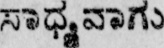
ಸಾಧ್ಯವಾಗು
